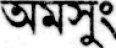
অমসুং
